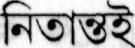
নিতান্তই
